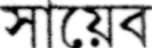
সায়েব
